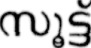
സൂട്ട്
